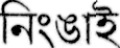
নিংঙাই
